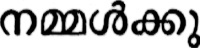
നമ്മള്‍ക്കു
